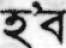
হ'ব
